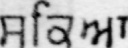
ਸਕਿਆ
